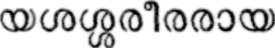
യശശ്ശരീരരായ
